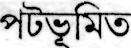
পটভূমিত
